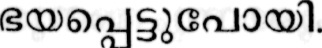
ഭയപ്പെട്ടുപോയി.
